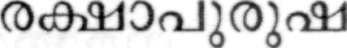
രക്ഷാപുരുഷ
